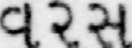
વરસ
